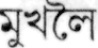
মুখলৈ
